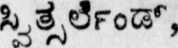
ಸ್ವಿತ್ಸರ್ಲೆಂಡ್,
